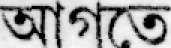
আগতে
